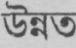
উন্নত
